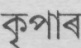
কৃপাৰ
